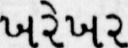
ખરેખર
